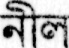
নীল
